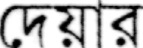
দেয়ার
